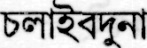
চলাইবদুনা
